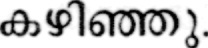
കഴിഞ്ഞു.
